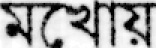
মখোয়
